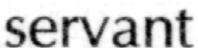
servant
